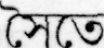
সৈতে
